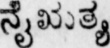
ನೈಋತ್ಯ
